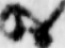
જ
